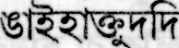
ঙাইহাক্তুদদি
